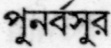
পুনর্বসুর
